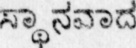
ಸ್ಥಾನವಾದ
